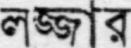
লজ্জার
